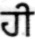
ਹੀ
